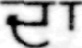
ਦਾ
